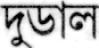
দুডাল
